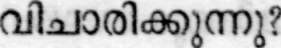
വിചാരിക്കുന്നു?
